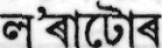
ল'ৰাটোৰ
